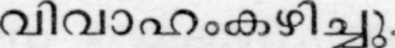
വിവാഹംകഴിച്ചു.
